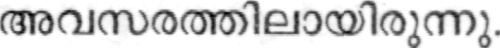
അവസരത്തിലായിരുന്നു.
